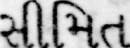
સીમિત
